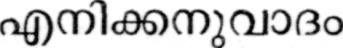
എനിക്കനുവാദം
